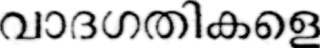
വാദഗതികളെ
